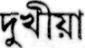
দুখীয়া
